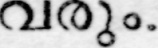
വരും.
